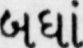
બધાં
